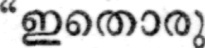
“ഇതൊരു
